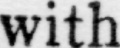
with
